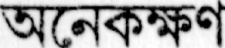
অনেকক্ষণ
